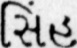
સિંહ
